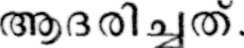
ആദരിച്ചത്.
